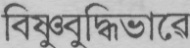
বিষ্ণুবুদ্ধিভাৱে
